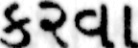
કરવા
